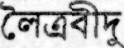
লৈত্রবীদু
